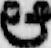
ಆ
